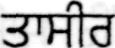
ਤਾਸੀਰ
